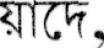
য়াদে,
